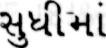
સુધીમાં
